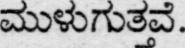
ಮುಳುಗುತ್ತವೆ.
